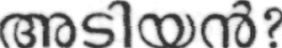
അടിയന്‍?
